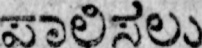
ಪಾಲಿಸಲು
